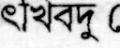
চৎখিবদু
